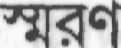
স্মরণ
